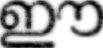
ഈ
